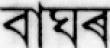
বাঘৰ
